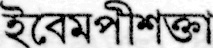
ইবেমপীশক্তা
